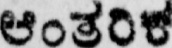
ಆಂತರಿಕ
